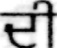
ਦੀ
